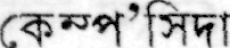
কেম্প’সিদা
